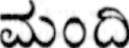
ಮಂದಿ
